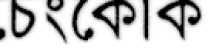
চেংকোক
